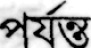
পর্যন্ত
